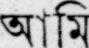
আমি
